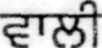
ਵਾਲੀ
